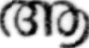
ആ
